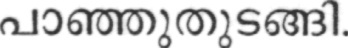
പാഞ്ഞുതുടങ്ങി.
